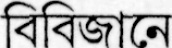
বিবিজানে
